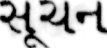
સૂચન
